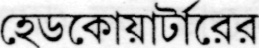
হেডকোয়ার্টারের
